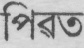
পিৱত
